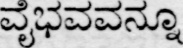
ವೈಭವವನ್ನೂ
